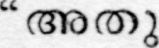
"അതു
